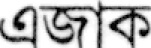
এজাক
